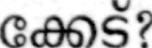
ക്കേട്?
